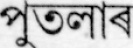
পুতলাৰ
